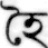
হৈ
